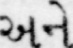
અને
